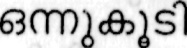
ഒന്നുകൂടി
